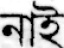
নাই
